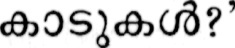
കാടുകള്‍?’
